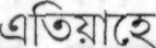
এতিয়াহে
